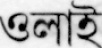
ওলাই
